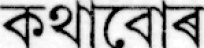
কথাবোৰ
